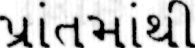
પ્રાંતમાંથી
